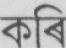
কৰি
